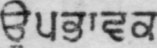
ਉਪਭਾਵਕ
